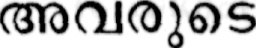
അവരുടെ
